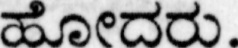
ಹೋದರು.
